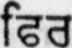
ਫਿਰ
